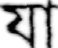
যা
